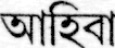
আহিবা
